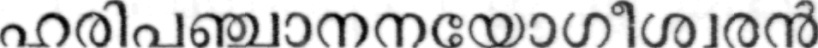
ഹരിപഞ്ചാനനയോഗീശ്വരന്‍
